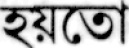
হয়তো
